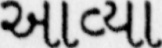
આવ્યા
